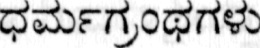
ಧರ್ಮಗ್ರಂಥಗಳು
